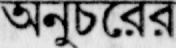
অনুচরের
